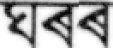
ঘৰৰ
